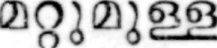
മറ്റുമുള്ള
